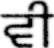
ਵੀ
